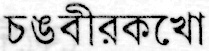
চঙবীরকখো
